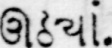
ઊઠ્યાં.
